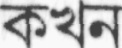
কখন
